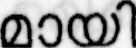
മായി
